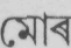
মোৰ
